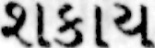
શકાય
